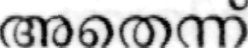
അതെന്ന്
